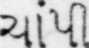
ચાંપી
